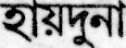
হায়দুনা
